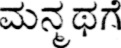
ಮನ್ಮಥಗೆ
